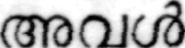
അവള്‍
